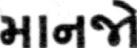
માનજો
